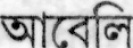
আবেলি
